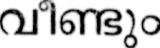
വീണ്ടും
